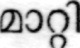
മാറ്റി
